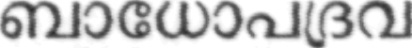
ബാധോപദ്രവ
